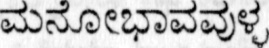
ಮನೋಭಾವವುಳ್ಳ
